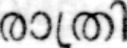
രാത്രി
